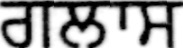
ਗਲਾਸ
